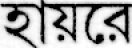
হায়রে
